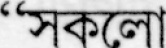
"সকলো
